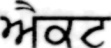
ਐਕਟ
